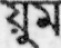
য়ুম
